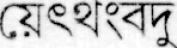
য়েৎথংবদু
